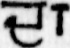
ਦਾ
